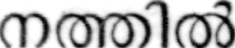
നത്തില്‍
